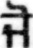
ਜੋ
